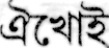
ঐখোই
